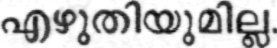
എഴുതിയുമില്ല.
